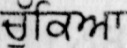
ਚੁੱਕਿਆ
